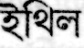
ইথিল
